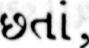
છતાં,
